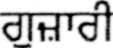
ਗੁਜ਼ਾਰੀ
